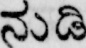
ನುಡಿ
